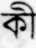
কী
